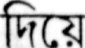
দিয়ে
